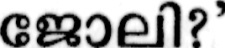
ജോലി?’
